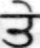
ਤੇ
